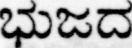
ಭುಜದ
